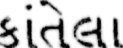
કાંતેલા
